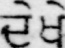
ਦੇਖੇ
